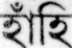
হাঁহি
